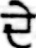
ਦੇ
